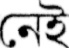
নেই
